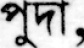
পুদা,
